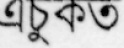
এচুকত
